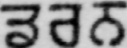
ਡਰਨ
